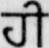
ਹੀ
